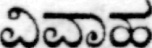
ವಿವಾಹ
